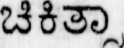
ಚಿಕಿತ್ಸಾ
